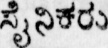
ಸೈನಿಕರು
